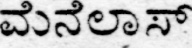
ಮೆನೆಲಾಸ್
